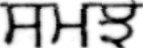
ਸਮਝ
